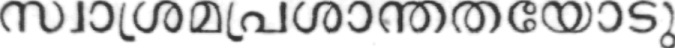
സ്വാശ്രമപ്രശാന്തതയോടു
